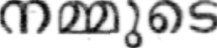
നമ്മുടെ
